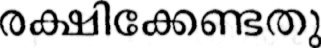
രക്ഷിക്കേണ്ടതു
